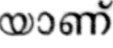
യാണ്
